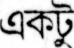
একটু
